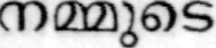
നമ്മുടെ
